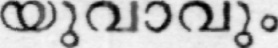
യുവാവും
